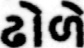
ઢોળે
